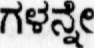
ಗಳನ್ನೇ
